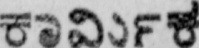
ಕಾರ್ಮಿಕ
